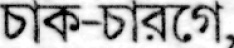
চাক-চারগে,
